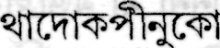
থাদোকপীনুকো
